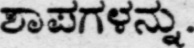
ಶಾಪಗಳನ್ನು.
